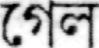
গেল
